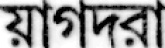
য়াগদরা
